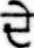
ਦੇ
